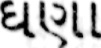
ઘણા
